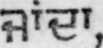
ਜਾਂਦਾ,
